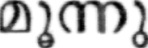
മൂന്നു
